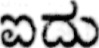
ಐದು
